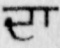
ਦਾ
